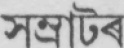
সম্ৰাটৰ
